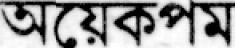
অয়েকপম
